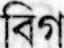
বিগ
